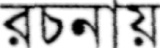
রচনায়
